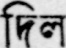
দিল
